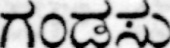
ಗಂಡಸು
